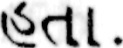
હતા.
